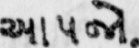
આપજો.
